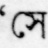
‘সে
